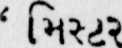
'મિસ્ટર
